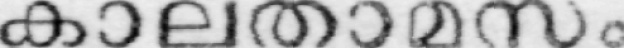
കാലതാമസം
